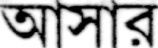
আসার
